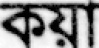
কয়া
